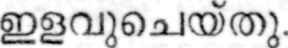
ഇളവുചെയ്തു.
